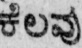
ಕೆಲವು
